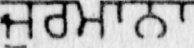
ਜੁਰਮਾਨਾ
